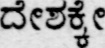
ದೇಶಕ್ಕೇ
